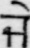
ਜੇ
